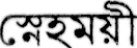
স্নেহময়ী
